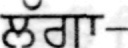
ਲੱਗਾ-
